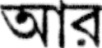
আর
